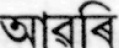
আৱৰি
